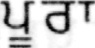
ਪੂਰਾ
